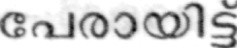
പേരായിട്ട്
